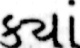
ક્યાં
